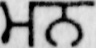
ਮਨ
